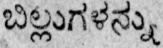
ಬಿಲ್ಲುಗಳನ್ನು
